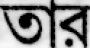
তার
